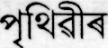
পৃথিৱীৰ
